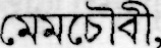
মেমচৌবী,
